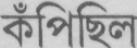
কঁপিছিল
